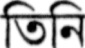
তিনি
